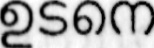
ഉടനെ
